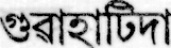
গুৱাহাটিদা
